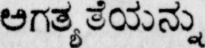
ಅಗತ್ಯತೆಯನ್ನು
